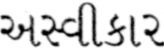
અસ્વીકાર
